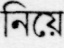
নিয়ে
